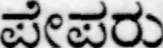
ಪೇಪರು
